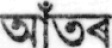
আঁতৰ
